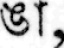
ঙা,
